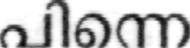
പിന്നെ
